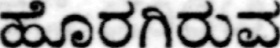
ಹೊರಗಿರುವ
